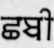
ਛਬੀ
